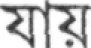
যায়
